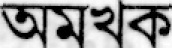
অমখক
